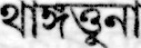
থাঙ্গত্তুনা
